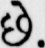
છે.
